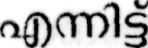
എന്നിട്ട്
